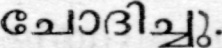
ചോദിച്ചു.
